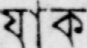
যাক
